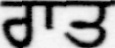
ਰਾਤ
